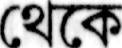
থেকে
